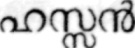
ഹസ്സന്‍
